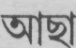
আছা
